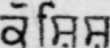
ਕੋਸ਼ਿਸ਼
